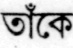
তাঁকে
